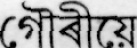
গৌৰীয়ে
